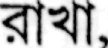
রাখা,
